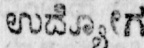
ಉದ್ಯೋಗ
